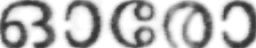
ഓരോ
